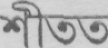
শীতত
